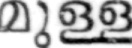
മുള്ള
